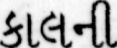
કાલની
